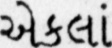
એકલાં
